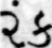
રંક
